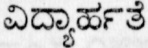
ವಿದ್ಯಾರ್ಹತೆ
